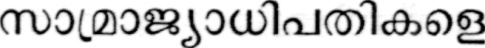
സാമ്രാജ്യാധിപതികളെ
